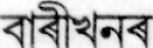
বাৰীখনৰ
